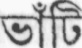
ভাঁটি
